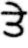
ਤੇ
